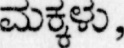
ಮಕ್ಕಳು,
